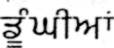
ਡੂੰਘੀਆਂ
